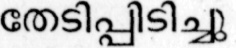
തേടിപ്പിടിച്ചു
